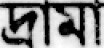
দ্রামা
